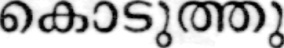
കൊടുത്തു
